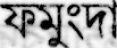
ফমুংদা
